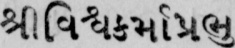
શ્રીવિશ્વકર્માપ્રભુ
